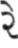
રે
